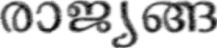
രാജ്യങ്ങ
